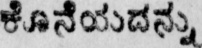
ಕೊನೆಯದನ್ನು
